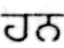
ਹਨ
